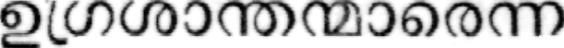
ഉഗ്രശാന്തന്മാരെന്ന
